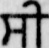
ਸੀ
